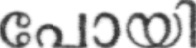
പോയി
